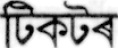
টিকটৰ
